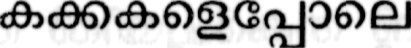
കക്കകളെപ്പോലെ
